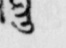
બધું
